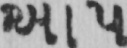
આપ
